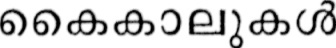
കൈകാലുകള്‍
